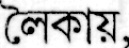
লৈকায়,
